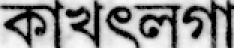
কাখৎলগা
